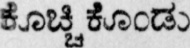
ಕೊಚ್ಚಿಕೊಂಡು
